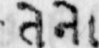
તેનો
